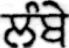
ਲੰਬੇ
